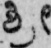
ಶ್ರೀ
